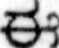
ಈ
